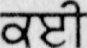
ਕਈ
